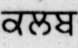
ਕਲਬ
